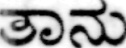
ತಾನು
